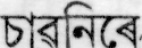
চাৱনিৰে
